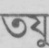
তযু
